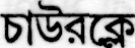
চাউরক্লে
